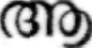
ആ
